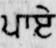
ਪਾਏ
